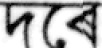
দৰে
